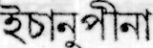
ইচানুপীনা
